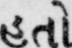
હતો
